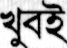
খুবই
